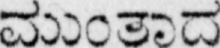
ಮುಂತಾದ
